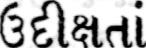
ઉદીક્ષતાં
